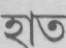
হাত
